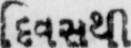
દિવસથી
